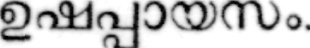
ഉഷപ്പായസം.
